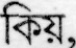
কিয়,
